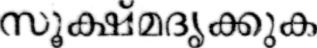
സൂക്ഷ്മദൃക്കുക
